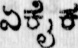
ಏಕೈಕ
